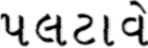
પલટાવે
